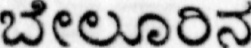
ಬೇಲೂರಿನ
